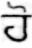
ਹੋ
